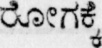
ರೋಗಕ್ಕೆ
